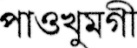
পাওখুমগী
